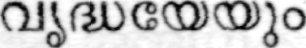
വൃദ്ധയേയും
